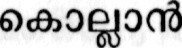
കൊല്ലാന്‍
